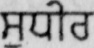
ਸੁਧੀਰ
